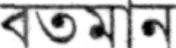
বতমান
